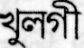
খুলগী
